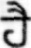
ਹੈ
